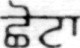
ਛੋਟਾ
